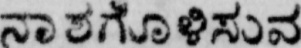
ನಾಶಗೊಳಿಸುವ
